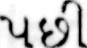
પછી
